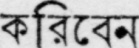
করিবেন
